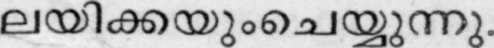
ലയിക്കയുംചെയ്യുന്നു.
